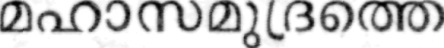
മഹാസമുദ്രത്തെ
